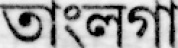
তাংলগা
